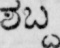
ಶಬ್ದ
